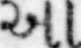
આ
